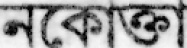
নকোক্তা
